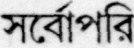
সর্বোপরি
